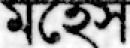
মহেস
